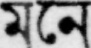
মনে
